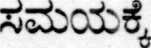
ಸಮಯಕ್ಕೆ
